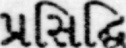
પ્રસિદ્ધિ
